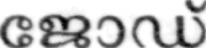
ജോഡ്
